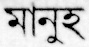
মানুহ
